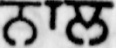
ਨਾਲ
